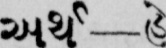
અર્થ-હે
